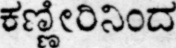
ಕಣ್ಣೀರಿನಿಂದ
